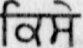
ਕਿਸੇ
